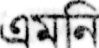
এমনি
